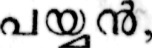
പയ്യന്‍,
